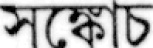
সঙ্কোচ
